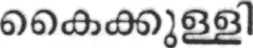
കൈക്കുള്ളി
